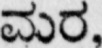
ಮರ,
